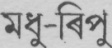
মধু-ৰিপু
